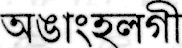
অঙাংহলগী
